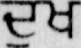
ਦੁਖ
